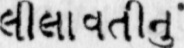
લીલાવતીનું
